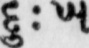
દુઃખ
